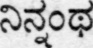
ನಿನ್ನಂಥ
